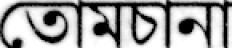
তোমচানা
